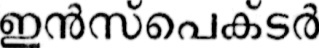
ഇന്‍സ്പെക്ടര്‍
